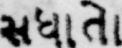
સધાતો
